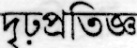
দৃঢ়প্রতিজ্ঞ
